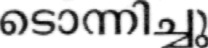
ടൊന്നിച്ചു
